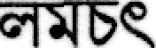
লমচৎ
